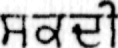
ਸਕਦੀ
